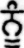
ਨੂੰ
